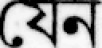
যেন
